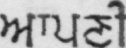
ਆਪਣੀ
